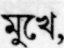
মুখে,
